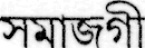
সমাজগী
